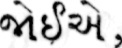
જોઈએ,
